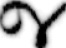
જ
